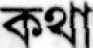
কথা
